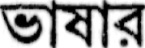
ভাষার
